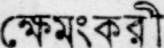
ক্ষেমংকরী
